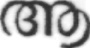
ആ
